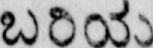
ಬರಿಯ
